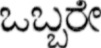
ಒಬ್ಬರೇ
